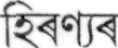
হিৰণ্যৰ
